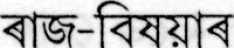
ৰাজ-বিষয়াৰ
